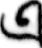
এ
